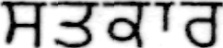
ਸਤਕਾਰ
